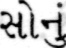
સોનું
